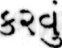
કરવું
